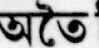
অতৈ
